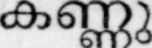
കണ്ണു
